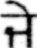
ਜੇ
